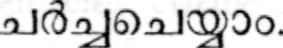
ചര്‍ച്ചചെയ്യാം.
